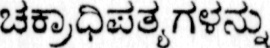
ಚಕ್ರಾಧಿಪತ್ಯಗಳನ್ನು
